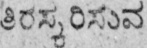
ತಿರಸ್ಕರಿಸುವ
